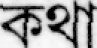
কথা
